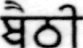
ਬੈਠੀ
